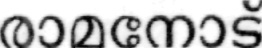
രാമനോട്
